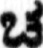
ಚ
